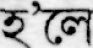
হ'লে
